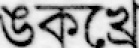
ঙকখ্রে
